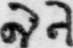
જેને
